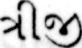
ત્રીજી
